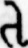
તે
